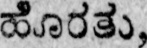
ಹೊರತು,
